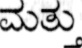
ಮತ್ತು
